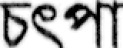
চৎপা
